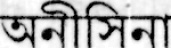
অনীসিনা
